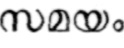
സമയം
